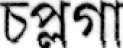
চপ্লগা
